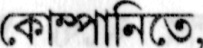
কোম্পানিতে,
